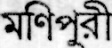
মণিপুরী
